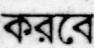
করবে
